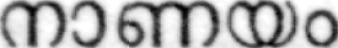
നാണയം
